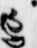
હું
